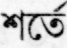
শর্তে
